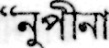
“নুপীনা
